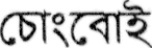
চোংবোই
